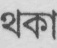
থকা
